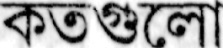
কতগুলো
